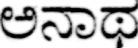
ಅನಾಥ
